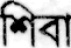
শিবা
